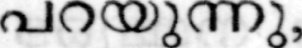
പറയുന്നു,
